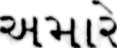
અમારે
